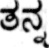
ತನ್ನ
